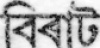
বিৰাট
